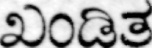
ಖಂಡಿತ
